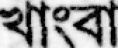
খাংবা
